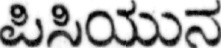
ಪಿಸಿಯುನ
